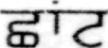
ਛਾਂਟ
